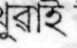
খুৱাই
